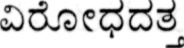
ವಿರೋಧದತ್ತ
